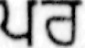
ਪਰ
